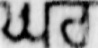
ਘਰ
